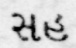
સહ
